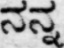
ನನ್ನ
